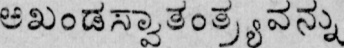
ಅಖಂಡಸ್ವಾತಂತ್ರ್ಯವನ್ನು
